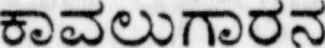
ಕಾವಲುಗಾರನ
